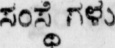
ಸಂಸ್ಥೆಗಳು
